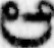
ಆ
